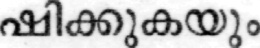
ഷിക്കുകയും
